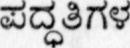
ಪದ್ಧತಿಗಳ
